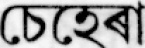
চেহেৰা
